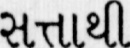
સત્તાથી
